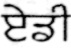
ਏਡੀ
